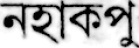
নহাকপু
